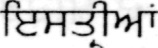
ਇਸਤ੍ਰੀਆਂ
